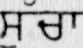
ਸੁੱਚਾ
